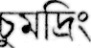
চুমদ্রিং
